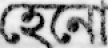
হেনো
